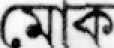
মোক
